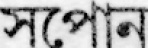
সপোন
